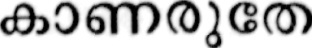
കാണരുതേ
